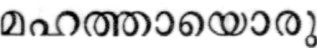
മഹത്തായൊരു
